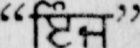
''ਇੰਜ''
